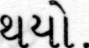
થયો.
